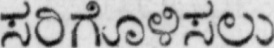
ಸರಿಗೊಳಿಸಲು
